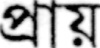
প্রায়
